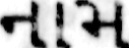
નામ
